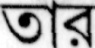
তার
